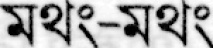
মথং-মথং
